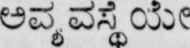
ಅವ್ಯವಸ್ಥೆಯೇ
